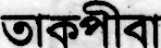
তাকপীবা
